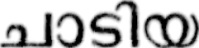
ചാടിയ
